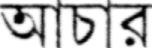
আচার
